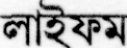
লাইফম
